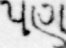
પણ
